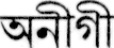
অনীগী
